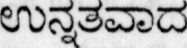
ಉನ್ನತವಾದ
